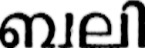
ബലി
